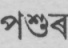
পশুৰ
